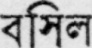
বসিল
